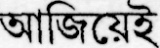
আজিয়েই
